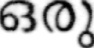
ഒരു
